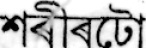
শৰীৰটো
